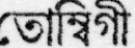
তোম্বিগী
